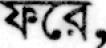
ফরে,
